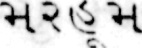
મરહૂમ
